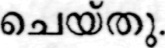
ചെയ്തു.
